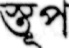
স্তূপ
